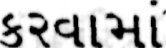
કરવામાં
